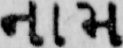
નામ
